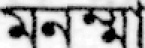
মনম্মা
